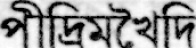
পীদ্রিমখৈদি
